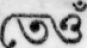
তেওঁ
